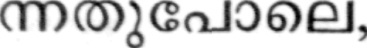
ന്നതുപോലെ,
